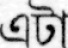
এটা
